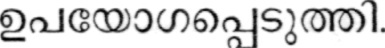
ഉപയോഗപ്പെടുത്തി.
